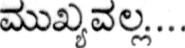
ಮುಖ್ಯವಲ್ಲ....
